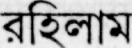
রহিলাম
